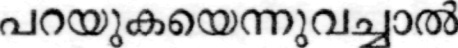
പറയുകയെന്നുവച്ചാല്‍
